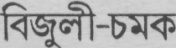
বিজুলী-চমক
